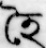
হৈ
